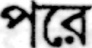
পরে
